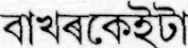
বাখৰকেইটা
